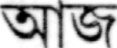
আজ
